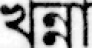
খন্না
